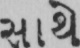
સાથે
